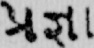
પ્રજ્ઞા
